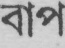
বাপ
